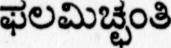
ಫಲಮಿಚ್ಛಂತಿ
